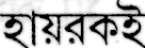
হায়রকই
